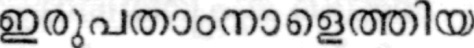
ഇരുപതാംനാളെത്തിയ
